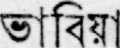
ভাবিয়া
